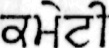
ਕਮੇਟੀ
